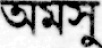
অমসু
